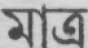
মাত্ৰ
